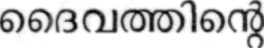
ദൈവത്തിന്റെ
